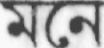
মনে
